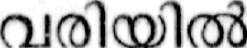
വരിയില്‍
